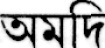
অমদি
